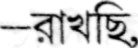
-রাখছি,
